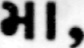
મા,
